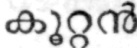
കൂറ്റന്‍
